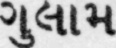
ગુલામ
